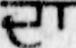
ਦਾ
